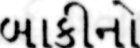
બાકીનો
